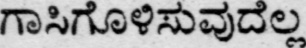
ಗಾಸಿಗೊಳಿಸುವುದೆಲ್ಲ
